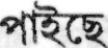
পাইছে
